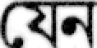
যেন
